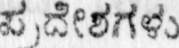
ಪ್ರದೇಶಗಳು
